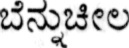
ಬೆನ್ನುಚೀಲ
